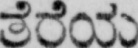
ತೆರೆಯ
